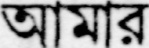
আমার
